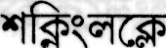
শক্নিংলক্লে
